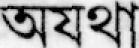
অযথা
